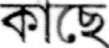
কাছে
